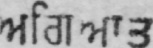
ਅਗਿਆਤ
